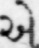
એ
